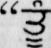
''ਤੂੰ
